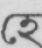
হে
